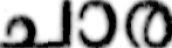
ചാര
